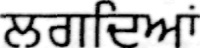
ਲਗਦਿਆਂ
